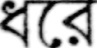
ধরে
